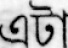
এটা
